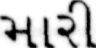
મારી
